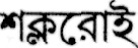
শক্লরোই
